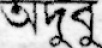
অদুবু
